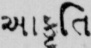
આકૃતિ
